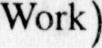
Work)
